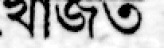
খোজত
